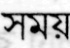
সময়
